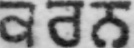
ਕਰਨ
